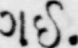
ગઈ.
